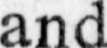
and
